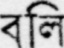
বলি
